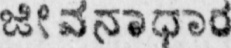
ಜೀವನಾಧಾರ
